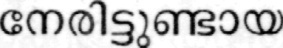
നേരിട്ടുണ്ടായ
